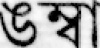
ঙম্বা
